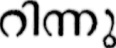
റിന്നു
